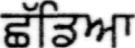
ਛੱਡਿਆ
